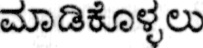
ಮಾಡಿಕೊಳ್ಳಲು
